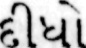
દીધો
